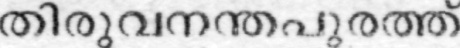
തിരുവനന്തപുരത്ത്
